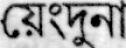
য়েংদুনা
